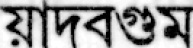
য়াদবগুম
